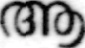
ആ
